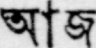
আজ
